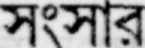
সংসার
